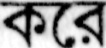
করে
